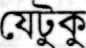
যেটুকু
